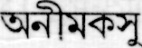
অনীমকসু
